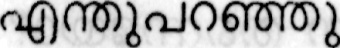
എന്തുപറഞ്ഞു
